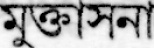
মুক্তাসনা
